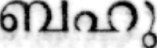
ബഹു
